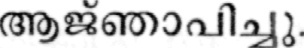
ആജ്ഞാപിച്ചു.
